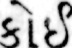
કોઈ
